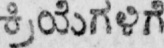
ಕ್ರಿಯೆಗಳಿಗೆ
